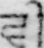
ਵੀ
